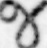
જ
